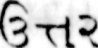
ઉત્તર
